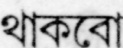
থাকবো
